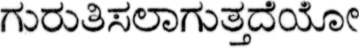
ಗುರುತಿಸಲಾಗುತ್ತದೆಯೋ
